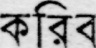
করিব
